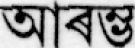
আৰম্ভ
